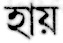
হায়
